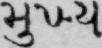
મુખ્ય
